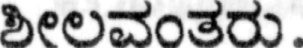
ಶೀಲವಂತರು.
